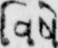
વિષે
